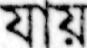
যায়
